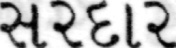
સરદાર
